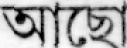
আছো
